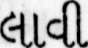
લાવી
